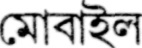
মোবাইল
